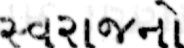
સ્વરાજનો
